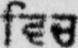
ਵਿਚ
